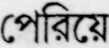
পেরিয়ে
